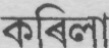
কৰিলা
